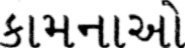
કામનાઓ
